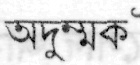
অদুম্মক
